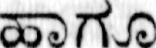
ಹಾಗೂ
